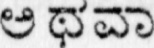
ಅಥವಾ
